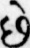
છે
